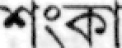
শংকা
